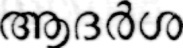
ആദര്‍ശ
